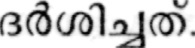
ദര്‍ശിച്ചത്.
